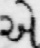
એ
